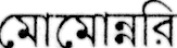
মোমোন্নরি
